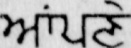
ਆਂਪਣੇ
